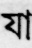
যা
